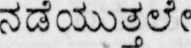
ನಡೆಯುತ್ತಲೇ
